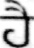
ਹੈ
